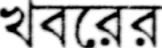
খবরের
